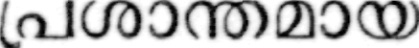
പ്രശാന്തമായ
